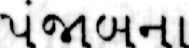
પંજાબના
